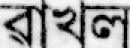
ৱাখল
